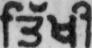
ਤਿੱਖੀ
